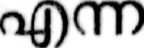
എന്ന
